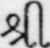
શ્રી
